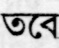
তবে
